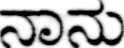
ನಾನು
